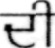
ਦੀ
